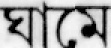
ঘামে
